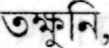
তক্ষুনি,
